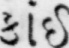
કાંઈ
